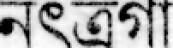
নৎত্রগা
